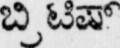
ಬ್ರಿಟಿಷ್
